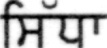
ਸਿੱਧਾ
